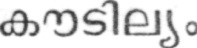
കൗടില്യം
